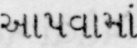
આપવામાં
